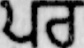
ਪਰ
